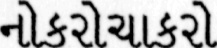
નોકરોચાકરો
